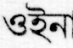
ওইনা
